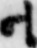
ન
